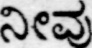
ನೀವು
